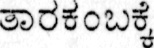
ತಾರಕಂಬಕ್ಕೆ
